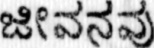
ಜೀವನವು
